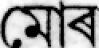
মোৰ
